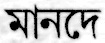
মানদে
